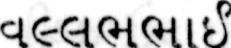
વલ્લભભાઈ
